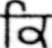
ਕਿ
